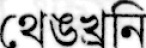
থেঙখ্রনি
